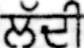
ਲੱਦੀ
